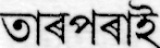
তাৰপৰাই
